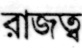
রাজত্ব
